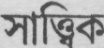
সাত্ত্বিক
